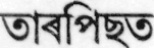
তাৰপিছত
